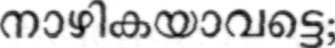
നാഴികയാവട്ടെ;
